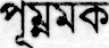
পূম্নমক
